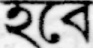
হবে
